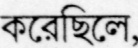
করেছিলে,
